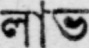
লাভ
